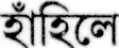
হাঁহিলে
